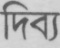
দিব্য
